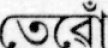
তেৱোঁ
